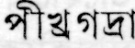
পীখ্রগদ্রা
